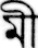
মী
